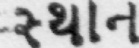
સ્થાન
